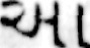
આ
